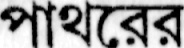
পাথরের
